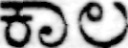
ಕಾಲ
